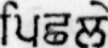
ਪਿਛਲੇ
